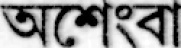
অশেংবা
